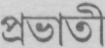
প্ৰভাতী
